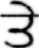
ਤੇ
